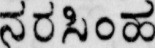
ನರಸಿಂಹ
